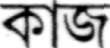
কাজ
